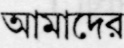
আমাদের
